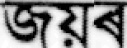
জয়ৰ
